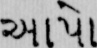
આપો
